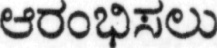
ಆರಂಭಿಸಲು
